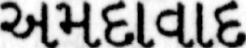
અમદાવાદ
